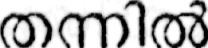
തന്നില്‍
